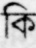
কি
